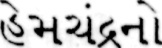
હેમચંદ્રનો
